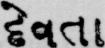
દેવતા
